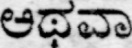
ಅಥವಾ
